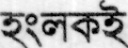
হংলকই
